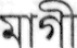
মাগী
